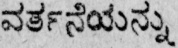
ವರ್ತನೆಯನ್ನು
